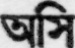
অসি
